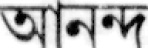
আনন্দ
